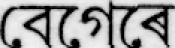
বেগেৰে
